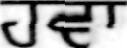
ਹਵਾ
